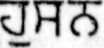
ਹੁਸਨ
